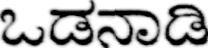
ಒಡನಾಡಿ
